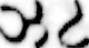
ઝટ
